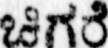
ಚಿಗರೆ
